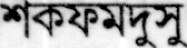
শকফমদুসু
